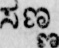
ಸಣ್ಣ
